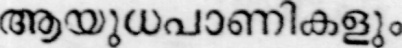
ആയുധപാണികളും
